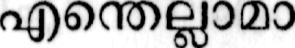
എന്തെല്ലാമാ
